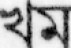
খম
